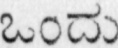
ಒಂದು
